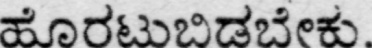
ಹೊರಟುಬಿಡಬೇಕು.
